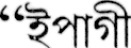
“ইপাগী
